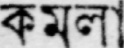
কমলা
